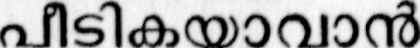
പീടികയാവാന്‍
